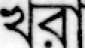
খরা
